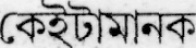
কেইটামানক
